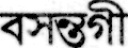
বসন্তগী
